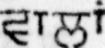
ਵਾਲਾਂ
